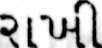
રાખી
